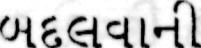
બદલવાની
